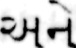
અને
